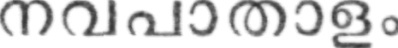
നവപാതാളം
